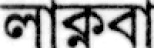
লাক্নবা
